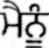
ਮੈਨੂੰ
